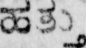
ಹತ್ತು
